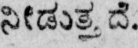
ನೀಡುತ್ತದೆ.
